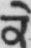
ਕੇ
